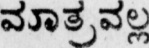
ಮಾತ್ರವಲ್ಲ
